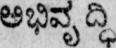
ಅಭಿವೃದ್ಧಿ
